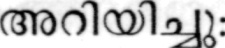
അറിയിച്ചു:
